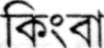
কিংবা
